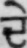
ਦੇ
